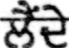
ਲੈਂਦੇ
